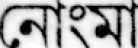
নোংমা
